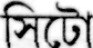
সিটো
